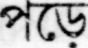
পড়ে
